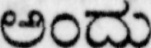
ಅಂದು
